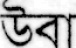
উবা
